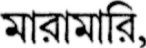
মারামারি,
